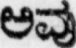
ಅವು
